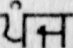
ਪੰਜ
